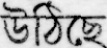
উঠিছে
